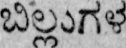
ಬಿಲ್ಲುಗಳ
